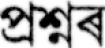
প্রশ্নৰ
